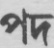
পদ
